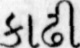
કાઢી
